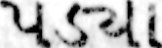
પડ્યા
